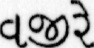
વજીરે
